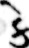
કે
